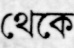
থেকে
